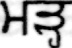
ਮੜ੍ਹ
